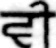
ਵੀ
